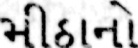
મીઠાનો
